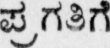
ಪ್ರಗತಿಗೆ
